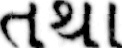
તથા
